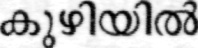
കുഴിയില്‍
